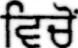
ਵਿਚੋਂ
